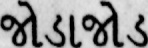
જોડાજોડ
